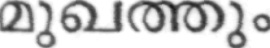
മുഖത്തും
